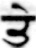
ਤੇ
